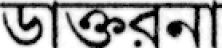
ডাক্তরনা
